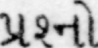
પ્રશ્નો
